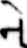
ને
